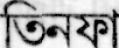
তিনফা
